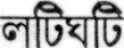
লটিঘটি
